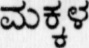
ಮಕ್ಕಳ
